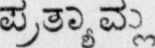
ಪ್ರತ್ಯಾಮ್ಲ
